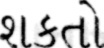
શકતો
